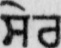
ਸੇਰ
